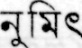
নুমিৎ
